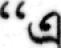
"এ
